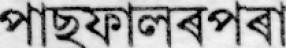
পাছফালৰপৰা
